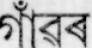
গাঁৱৰ
